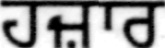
ਹਜ਼ਾਰ
